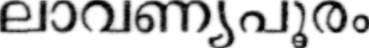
ലാവണ്യപൂരം
